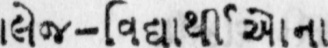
લેજ-વિદ્ાર્થીઓના
